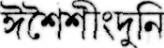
ঈশৈশীংদুনি
